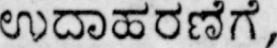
ಉದಾಹರಣೆಗೆ,
